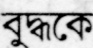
বুদ্ধকে
